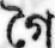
গৈ
